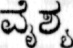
ವೈಶ್ಯ
